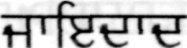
ਜਾਇਦਾਦ
